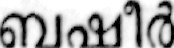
ബഷീര്‍
